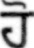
ਹੋ
